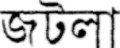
জটলা
